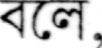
বলে,
